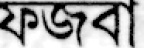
ফজবা
